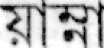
য়াম্না
